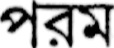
পরম
